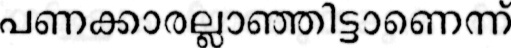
പണക്കാരല്ലാഞ്ഞിട്ടാണെന്ന്
